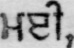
ਮਈ,
